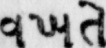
વખતે
